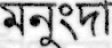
মনুংদা
